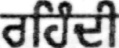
ਰਹਿੰਦੀ
